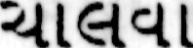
ચાલવા
